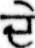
ਦੇ
